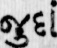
જુદાં
